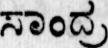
ಸಾಂದ್ರ
